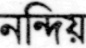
নন্দিয়
